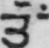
ਤੋਂ
